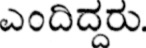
ಎಂದಿದ್ದರು.
